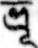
ভ্রূ
